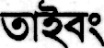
তাইবং
